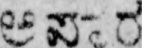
ಅಪಾರ
